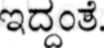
ಇದ್ದಂತೆ.
